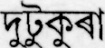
দুটুকুৰা
